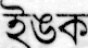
ইঙক
